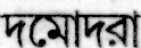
দমোদরা
